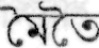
মৈতৈ
